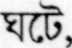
ঘটে,
